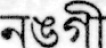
নঙগী
